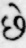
છે
